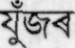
যুঁজৰ
